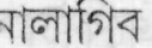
নালাগিব
